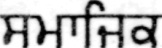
ਸਮਾਜਿਕ
